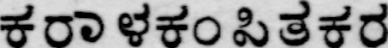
ಕರಾಳಕಂಪಿತಕರ
